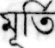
মূর্তি
